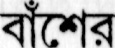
বাঁশের
